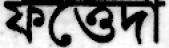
ফত্তেদা
